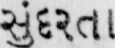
સુંદરતા
